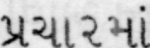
પ્રચારમાં
